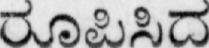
ರೂಪಿಸಿದ
